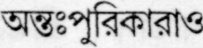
অন্তঃপুরিকারাও
